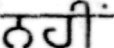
ਨਹੀਂ
